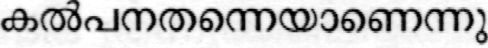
കല്‍പനതന്നെയാണെന്നു
